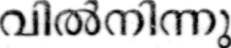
വില്‍നിന്നു
